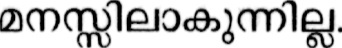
മനസ്സിലാകുന്നില്ല.
